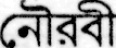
নৌরবী
